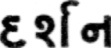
દર્શન
